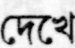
দেখে
